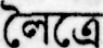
লৈত্রে
